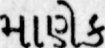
માણેક
